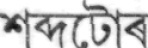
শব্দটোৰ
